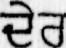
ਦੇਰ
